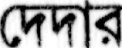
দেদার
